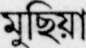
মুছিয়া
